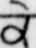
ਕੇ
